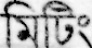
মিটিং
